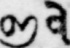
જીવે
